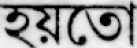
হয়তো
